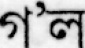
গ'ল
